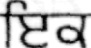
ਇਕ
